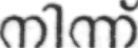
നിന്ന്
